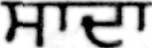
ਸਾਦਾ
